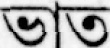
ভাত
